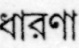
ধারণা
